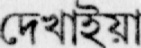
দেখাইয়া
